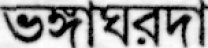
ভঙ্গাঘরদা
